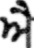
ਐ
